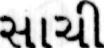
સાચી
